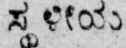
ಸ್ಥಳೀಯ
